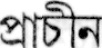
প্রাচীন
